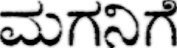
ಮಗನಿಗೆ
